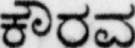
ಕೌರವ
